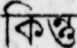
কিন্তু
